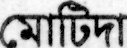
মোটিদা
